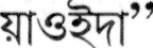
য়াওইদা”
